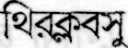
থিরক্লবসু
